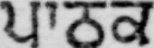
ਪਾਠਕ
